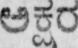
ಅಕ್ಷರ
